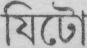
যিটো
